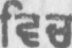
ਵਿਚ
